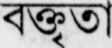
বক্তৃতা
